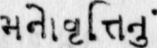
મનોવૃત્તિનું
